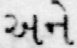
અને
